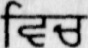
ਵਿਚ
